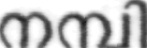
നമ്പി
